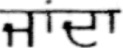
ਜਾਂਦਾ
